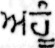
ਅਹੂੰ
